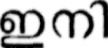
ഇനി
